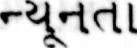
ન્યૂનતા
